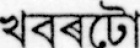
খবৰটো
